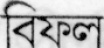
বিফল
